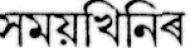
সময়খিনিৰ
